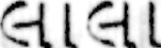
લાલા
